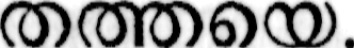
തത്തയെ.
